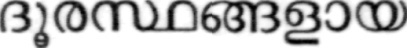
ദൂരസ്ഥങ്ങളായ
